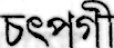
চৎপগী
